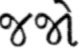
જજો
